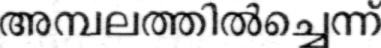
അമ്പലത്തില്‍ച്ചെന്ന്
